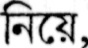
নিয়ে,
